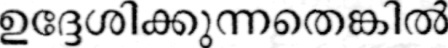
ഉദ്ദേശിക്കുന്നതെങ്കില്‍
